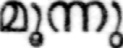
മൂന്നു
